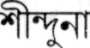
শীন্দুনা
